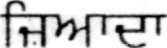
ਜ਼ਿਆਦਾ
